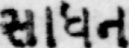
સાધન
